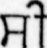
ਸੀ
